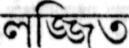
লজ্জিত
